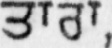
ਤਾਰਾ,
